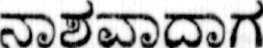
ನಾಶವಾದಾಗ
